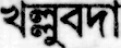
খল্লুবদা
